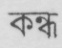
কন্ধ
